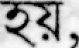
হয়,
